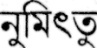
নুমিৎতু
